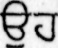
ਉਹ
